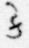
કે
